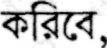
করিবে,
